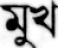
মুখ
